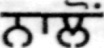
ਨਾਲੋਂ
